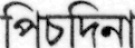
পিচদিনা
